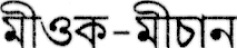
মীওক-মীচান
